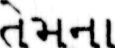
તેમના
